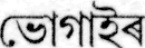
ভোগাইৰ
